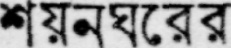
শয়নঘরের
